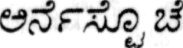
ಅರ್ನೆಸ್ಟೊಚೆ
